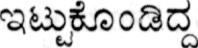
ಇಟ್ಟುಕೊಂಡಿದ್ದ
